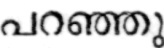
പറഞ്ഞു
